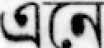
এনে
